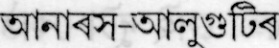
আনাৰস-আলুগুটিৰ
